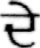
ਦੇ
